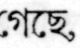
গেছে,
